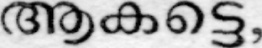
ആകട്ടെ,
